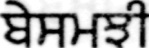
ਬੇਸਮਝੀ
